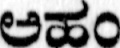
ಅಹಂ
